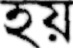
হয়
